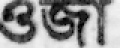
ওজা
